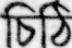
চিঠি
